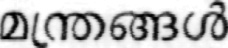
മന്ത്രങ്ങള്‍
